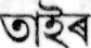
তাইৰ
